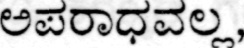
ಅಪರಾಧವಲ್ಲ,
